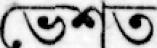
ভেশত
